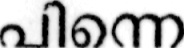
പിന്നെ
